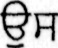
ਉਸ
